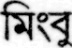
মিংবু
